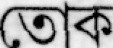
তোক
